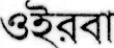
ওইরবা
